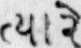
ત્યારે
